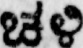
ಚಳಿ
